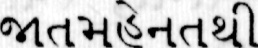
જાતમહેનતથી
